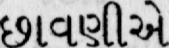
છાવણીએ
